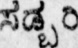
ಸಡ್ಬರಿ
